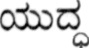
ಯುದ್ಧ
